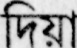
দিয়া
